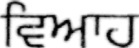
ਵਿਆਹ
